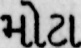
મોટા
